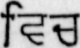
ਵਿਚ
